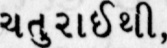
ચતુરાઈથી,
